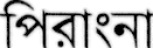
পিরাংনা
